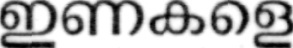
ഇണകളെ
